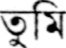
তুমি
